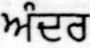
ਅੰਦਰ
